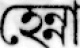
হেন্না
